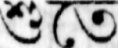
শুতে
